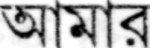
আমার
